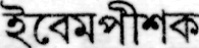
ইবেমপীশক
